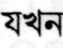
যখন
